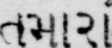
તમારાં
